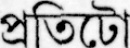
প্রতিটো
